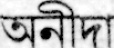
অনীদা
